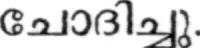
ചോദിച്ചു.
